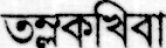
তম্লকখিবা
